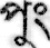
পুং
